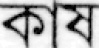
কাষ
